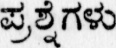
ಪ್ರಶ್ನೆಗಳು
